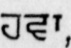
ਹਵਾ,
